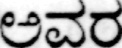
ಅವರ
